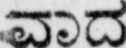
ವಾದ
